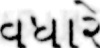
વધારે
